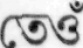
তেওঁ
